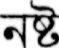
নষ্ট
